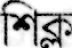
শিক্ল
